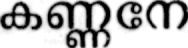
കണ്ണനേ
